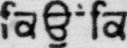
ਕਿਉਂਕਿ
